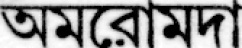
অমরোমদা
